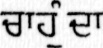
ਚਾਹੁੰਦਾ
